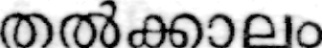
തല്‍ക്കാലം
